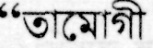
“তামোগী
